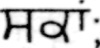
ਸਕਾਂ;
